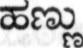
ಹಣ್ಣು
